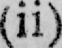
(ii)
